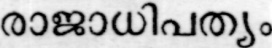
രാജാധിപത്യം
